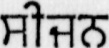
ਸੀਜਨ
